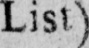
List)
